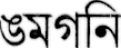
ঙমগনি
